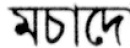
মচাদো
